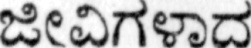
ಜೀವಿಗಳಾದ
